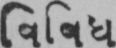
વિવિધ
